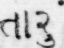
તારું
